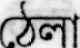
ঠেলা
